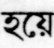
হয়ে
